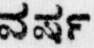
ವರ್ಷ
